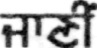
ਜਾਣੀਂ
